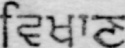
ਵਿਖਾਣ
